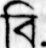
বি.
